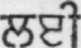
ਲਈ
